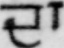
ਦਾ
